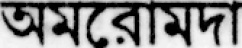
অমরোমদা
